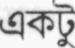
একটু
